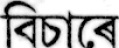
বিচাৰে
